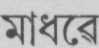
মাধৱে
